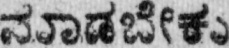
ಮಾಡಬೇಕು
